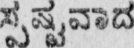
ಸ್ಪಷ್ಟವಾದ
